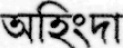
অহিংদা
